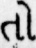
તો
